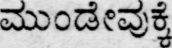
ಮುಂಡೇವುಕ್ಕೆ
